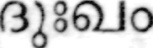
ദുഃഖം
